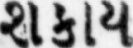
શકાય
